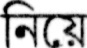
নিয়ে
